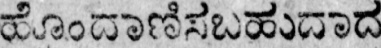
ಹೊಂದಾಣಿಸಬಹುದಾದ
